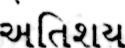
અતિશય
